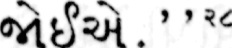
જોઈએ."૨૮
